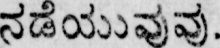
ನಡೆಯುವುವು.
